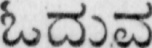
ಓದುವ
